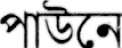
পাউনে
